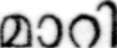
മാറി
